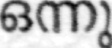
ഒന്നു
